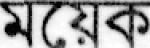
ময়েক
